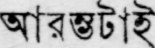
আরম্ভটাই
